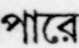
পারে
